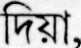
দিয়া,
